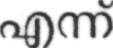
എന്ന്
